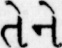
તેને
